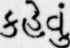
કહેવું
